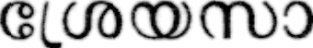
ശ്രേയസാ
